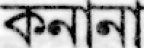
কনানা
